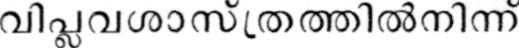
വിപ്ലവശാസ്ത്രത്തില്‍നിന്ന്
